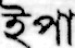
ইপা
